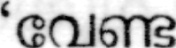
‘വേണ്ട
